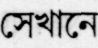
সেখানে
